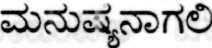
ಮನುಷ್ಯನಾಗಲಿ
